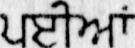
ਪਈਆਂ
